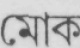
মোক
